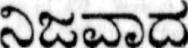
ನಿಜವಾದ
